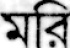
মরি
